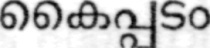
കൈപ്പടം
